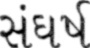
સંઘર્ષ
